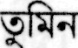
তুমিন
